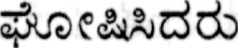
ಘೋಷಿಸಿದರು
